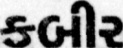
કબીર
